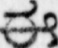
ಈ
